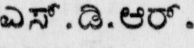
ಎಸ್.ಡಿ.ಆರ್.
